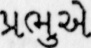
પ્રભુએ
